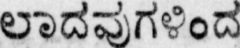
ಲಾದವುಗಳಿಂದ
